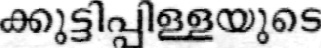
ക്കുട്ടിപ്പിള്ളയുടെ
